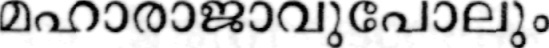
മഹാരാജാവുപോലും
